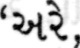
'અરે,
